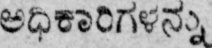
ಅಧಿಕಾರಿಗಳನ್ನು
